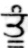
ਤੂੰ
